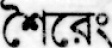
শৈরেং
